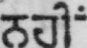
ਨਹੀਂ
